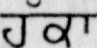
ਹੱਕਾਂ
